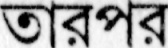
তারপর
